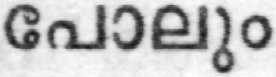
പോലും
